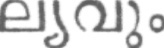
ല്യവും
